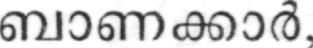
ബാണക്കാര്‍,
